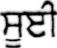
ਸੂਈ
